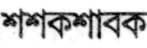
শশকশাবক
